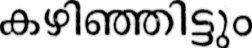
കഴിഞ്ഞിട്ടും
